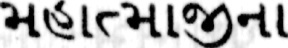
મહાત્માજીના
